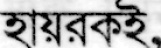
হায়রকই,
